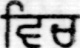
ਵਿਚ
